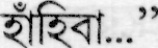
হাঁহিবা..."
